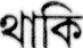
থাকি
